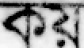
কয়
